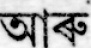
আৰু
